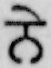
ਨੇ
